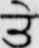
ਤੇ
